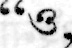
“ও,
